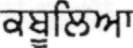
ਕਬੂਲਿਆ
